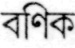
বণিক
